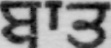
ਬਾਤ
